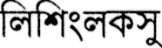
লিশিংলকসু
